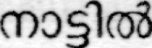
നാട്ടില്‍
